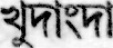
খুদাংদা
